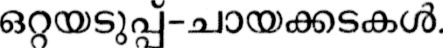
ഒറ്റയടുപ്പ്-ചായക്കടകള്‍.
